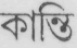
কান্তি
